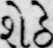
શેઠે
